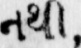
નથી,
